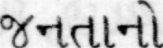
જનતાનો
